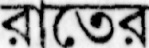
রাতের
